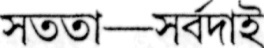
সততা-সর্বদাই
